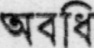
অবধি
